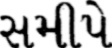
સમીપે
